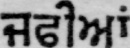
ਜਫੀਆਂ
